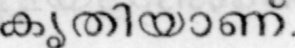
കൃതിയാണ്.
